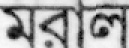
মরাল
